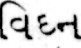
વિઘ્ન
